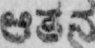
ಆತನ
